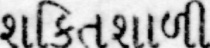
શક્તિશાળી
